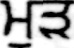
ਮੁੜ
